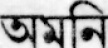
অমনি
